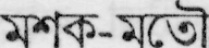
মশক-মতৌ
